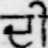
ਦੀ
